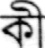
কী
